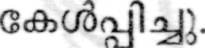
കേള്‍പ്പിച്ചു.
